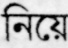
নিয়ে
